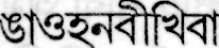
ঙাওহনবীখিবা
